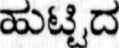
ಹುಟ್ಟಿದ
